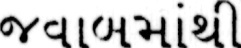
જવાબમાંથી
